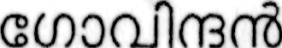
ഗോവിന്ദന്‍
